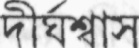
দীর্ঘশ্বাস
